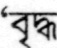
‘বৃদ্ধ
